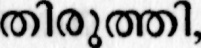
തിരുത്തി,
